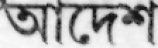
আদেশ
